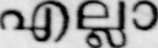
എല്ലാ
